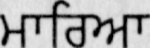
ਮਾਰਿਆ
